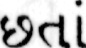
છતાં
